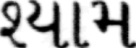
શ્યામ
